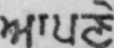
ਆਪਣੇ
